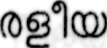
രളീയ
